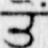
ਤੋਂ
